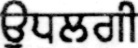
ਉਧਲਗੀ
